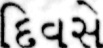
દિવસે
